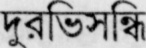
দুরভিসন্ধি
